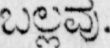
ಬಲ್ಲವು.
